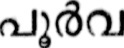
പൂര്‍വ
